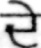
ਦੇ
